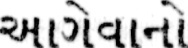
આગેવાનો
